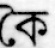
কৈ
